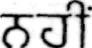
ਨਹੀਂ
